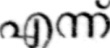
എന്ന്
